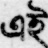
এই
